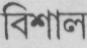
বিশাল
